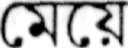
মেয়ে
